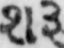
શરૂ
